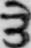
ਤੇ
